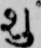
શું
